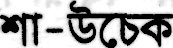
শা-উচেক
